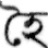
হৈ
